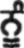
ਨੂੰ
